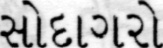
સોદાગરો
